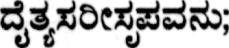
ದೈತ್ಯಸರೀಸೃಪವನು;
